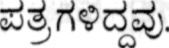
ಪತ್ರಗಳಿದ್ದವು.
